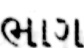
ભાગ
